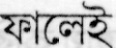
ফালেই
